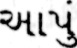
આપું
